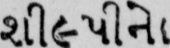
શીલ્પીનો
